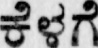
ಕೆಳಗೆ
